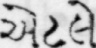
એટલે
